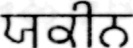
ਯਕੀਨ
